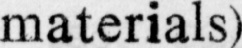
materials)
